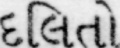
દલિતો
